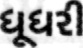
ધૂધરી
